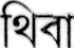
থিবা
